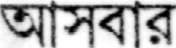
আসবার
